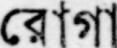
রোগা
